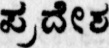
ಪ್ರದೇಶ
